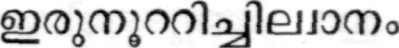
ഇരുന്നൂററിച്ചില്വാനം
